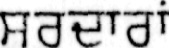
ਸਰਦਾਰਾਂ
